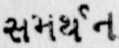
સમર્થન
